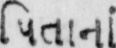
પિતાનાં
